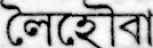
লৈহৌবা
